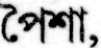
পৈশা,
